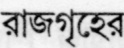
রাজগৃহের
